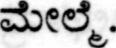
ಮೇಲ್ಮೆ.
